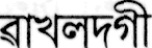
ৱাখলদগী
